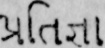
પ્રતિજ્ઞા
